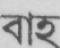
বাহ
